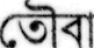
তৌবা
